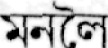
মনলৈ
